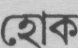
হোক
